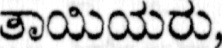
ತಾಯಿಯರು,
